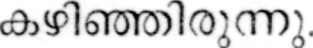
കഴിഞ്ഞിരുന്നു.
